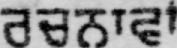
ਰਚਨਾਵਾਂ
